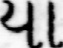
યા
